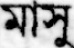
মাসু
